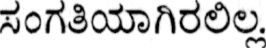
ಸಂಗತಿಯಾಗಿರಲಿಲ್ಲ.
